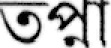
তপ্না
